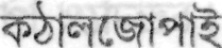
কঠালজোপাই
